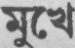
মুখে
